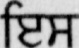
ਇਸ
